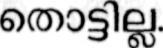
തൊട്ടില്ല.
